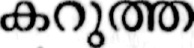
കറുത്ത
